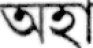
অহা
